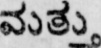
ಮತ್ತು
